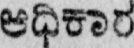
ಅಧಿಕಾರ
